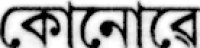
কোনোৱে
